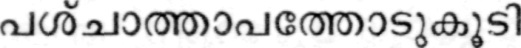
പശ്ചാത്താപത്തോടുകൂടി
